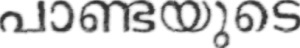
പാണ്ടയുടെ
